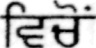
ਵਿਚੋਂ
